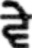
ਵੇ
